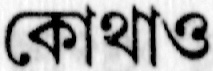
কোথাও
